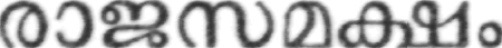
രാജസമക്ഷം
